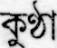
কুণ্ঠা
